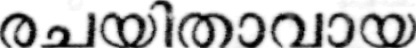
രചയിതാവായ
